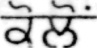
ਕੋਲੋਂ
